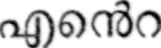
എന്റെ
